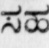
ಸಹ
